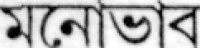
মনোভাব
